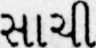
સાચી
